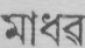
মাধৱ
